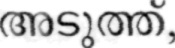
അടുത്ത്,
